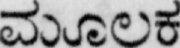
ಮೂಲಕ
